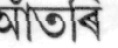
আঁতৰি
